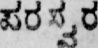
ಪರಸ್ವರ
